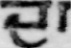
ਦਾ
